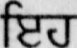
ਇਹ
